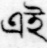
এই
